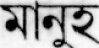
মানুহ
